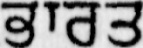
ਭਾਰਤ
